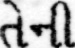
તેની
